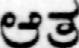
ಆತ
